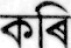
কৰি
